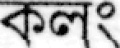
কলং
